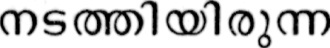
നടത്തിയിരുന്ന
